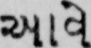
આવે
